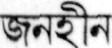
জনহীন
